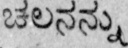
ಚಲನನ್ನು
